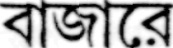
বাজারে
